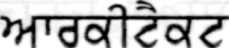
ਆਰਕੀਟੈਕਟ
